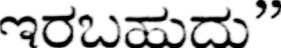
ಇರಬಹುದು"
